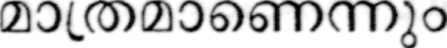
മാത്രമാണെന്നും
